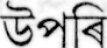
উপৰি
